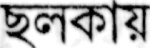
ছলকায়
